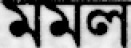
মমল
